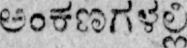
ಅಂಕಣಗಳಲ್ಲಿ
